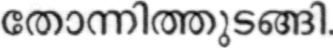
തോന്നിത്തുടങ്ങി.
